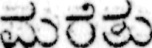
ಮರೆತು
